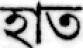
হাত
